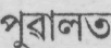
পুৱালত
